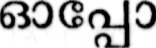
ഓപ്പോ
